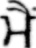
ਮੈਂ
